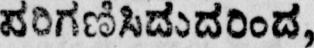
ಪರಿಗಣಿಸಿದುದರಿಂದ,
